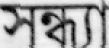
সন্ধ্যা
